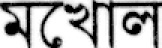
মখোল
